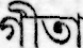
গীতা
